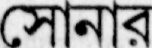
সোনার
